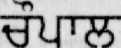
ਚੌਪਾਲ
